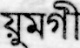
য়ুমগী
